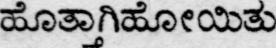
ಹೊತ್ತಾಗಿಹೋಯಿತು
